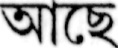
আছে
